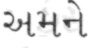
અમને
